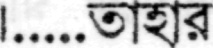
৷...তাহার
